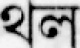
থল
